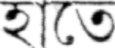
হাতে
